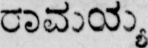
ರಾಮಯ್ಯ
